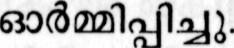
ഓര്‍മ്മിപ്പിച്ചു.
